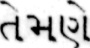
તેમણે
